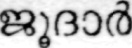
ജൂദാര്‍
